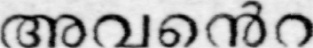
അവന്റെ
